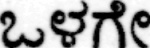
ಒಳಗೇ
